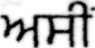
ਅਸੀਂ
